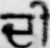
ਦੀ
